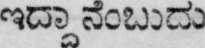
ಇದ್ದಾನೆಂಬುದು
